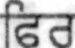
ਫਿਰ
